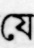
যে
